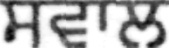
ਸਵਾਲ
